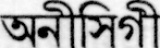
অনীসিগী
